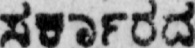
ಸರ್ಕಾರದ
